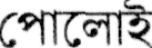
পোলোই
